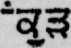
ਕੁੜ
